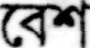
বেশ
